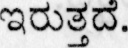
ಇರುತ್ತದೆ.
